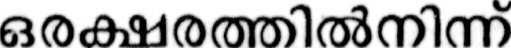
ഒരക്ഷരത്തില്‍നിന്ന്
